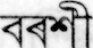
বৰশী
